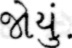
જોયું.
